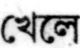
খেলে
